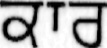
ਕਾਰ
